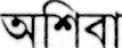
অশিবা
